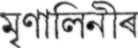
মৃণালিনীৰ
